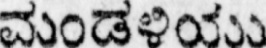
ಮಂಡಳಿಯು
